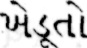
ખેડૂતો
